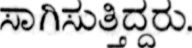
ಸಾಗಿಸುತ್ತಿದ್ದರು.
